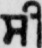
ਸੀ
